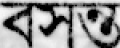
বসন্ত
